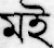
মই
